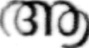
ആ
